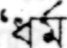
‘ধর্ম
